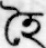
হৈ
